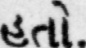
હતો.
